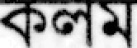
কলম
